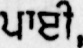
ਪਾਈ,
